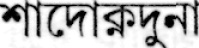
শাদোক্নদুনা
